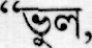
"ভুল,
